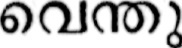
വെന്തു
